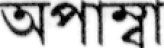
অপাম্বা
